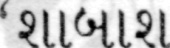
'શાબાશ
